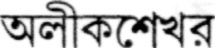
অলীকশেখর
